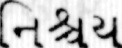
નિશ્ચય
